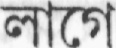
লাগে
